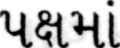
પક્ષમાં
